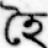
হৈ
